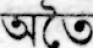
অতৈ
